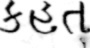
કહત
